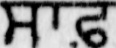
ਸਾਫ਼
